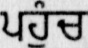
ਪਹੁੰਚ
